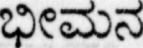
ಭೀಮನ
